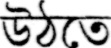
উঠতে
